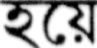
হয়ে
